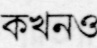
কখনও
